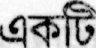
একটি
